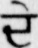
ਦੇ
